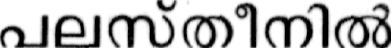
പലസ്തീനില്‍
